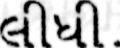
લીધી.
